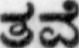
ತವೆ
